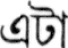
এটা
